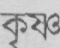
কৃষ্ণ
